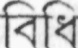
বিধি
